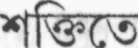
শক্তিতে
